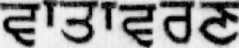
ਵਾਤਾਵਰਣ
